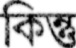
কিন্তু
